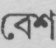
বেশ
